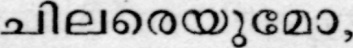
ചിലരെയുമോ,
